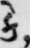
કે,
